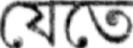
যেতে
